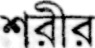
শরীর
